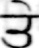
ਤੇ
